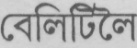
বেলিটিলৈ
